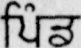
ਪਿੰਡ
